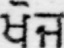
ਖੋਜ
